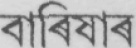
বাৰিষাৰ
